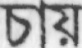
চায়
